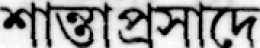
শান্তাপ্রসাদে
